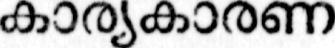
കാര്യകാരണ
